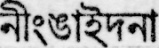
নিংঙাইদনা
